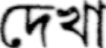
দেখা
